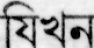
যিখন
